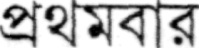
প্রথমবার
